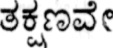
ತಕ್ಷಣವೇ
